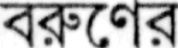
বরুণের
